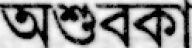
অশুবকা
